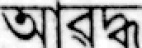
আৱদ্ধ
